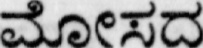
ಮೋಸದ
